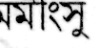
মমীংসু
